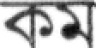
কম
